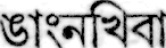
ঙাংনখিবা
